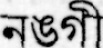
নঙগী
